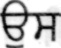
ਉਸ
